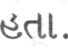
હતા.
